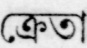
ক্রেতা
